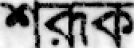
শরূক
